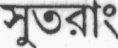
সুতরাং
